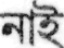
নাই
